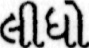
લીધો
